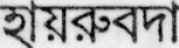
হায়রুবদা
